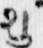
શું
